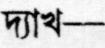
দ্যাখ–
